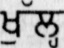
ਖੁੱਲ੍ਹ
